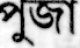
পুজা
